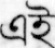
এই
